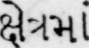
ક્ષેત્રમાં
